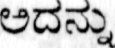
ಅದನ್ನು
